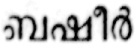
ബഷീര്‍
